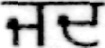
ਜਦ
